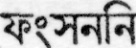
ফংসননি
